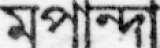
মপান্দা
